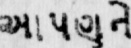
આપણને
